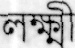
লক্ষ্মী
